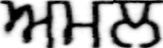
ਅਮਲ
